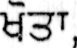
ਖੋਤਾ,
